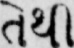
તેથી
